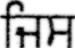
ਜਿਸ
